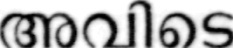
അവിടെ
